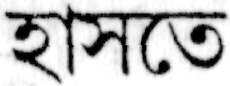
হাসতে
